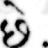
છે.
